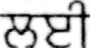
ਲਈ
